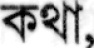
কথা,
